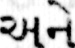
અને
